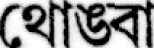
থোঙবা
